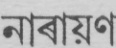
নাৰায়ণ
